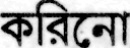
করিনো
